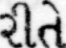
રીતે
